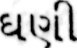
ઘણી
